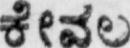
ಕೇವಲ
